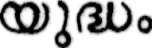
യുദ്ധം
